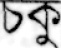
চকু
